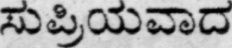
ಸುಪ್ರಿಯವಾದ
